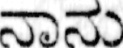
ನಾನು
